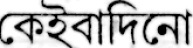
কেইবাদিনো
